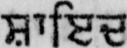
ਸ਼ਾਇਦ
